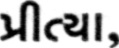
પ્રીત્યા,
